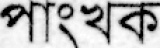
পাংখক
